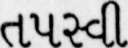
તપસ્વી
